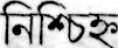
নিশ্চিহ্ন
